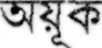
অয়ূক
